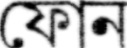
ফোন
